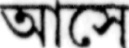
আসে
